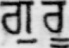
ਗੁਰੂ
